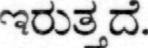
ಇರುತ್ತದೆ.
